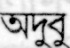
অদুবু
